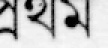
প্রথম
